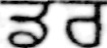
ਡਰ
